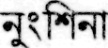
নুংশিনা
